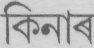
কিনাৰ
